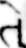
તે
